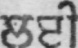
ਲਈ
